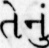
તેનું
